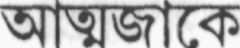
আত্মজাকে
